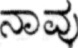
ನಾವು
